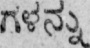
ಗಳನ್ನು
